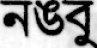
নঙবু
